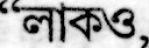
“লাকও,
